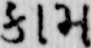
કામ
